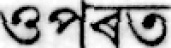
ওপৰত
